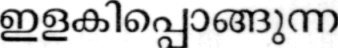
ഇളകിപ്പൊങ്ങുന്ന
